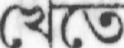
খেতে
